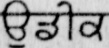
ਉਡੀਕ
